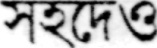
সহদেও
